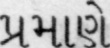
પ્રમાણે
